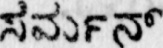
ಸರ್ಮನ್
